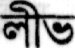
লীভ
